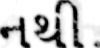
નથી.
